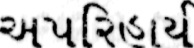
અપરિહાર્ય
